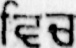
ਵਿਚ
